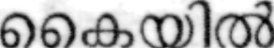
കൈയില്‍
